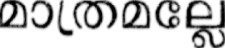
മാത്രമല്ലേ
